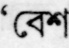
‘বেশ
